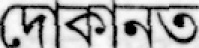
দোকানত
